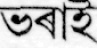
ভৰাই
